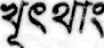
খূৎথাং
